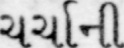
ચર્ચાની
